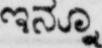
ಇನ್ನೂ
